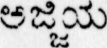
ಅಜ್ಜಿಯ
